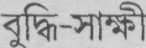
বুদ্ধি-সাক্ষী
